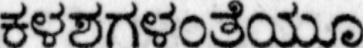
ಕಳಶಗಳಂತೆಯೂ
